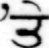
'ਤੇ
